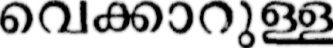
വെക്കാറുള്ള
